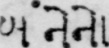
બંનેનો
